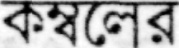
কম্বলের
